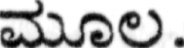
ಮೂಲ.
